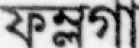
ফম্লগা
